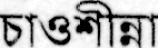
চাওশীন্না
